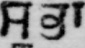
ਸੁਭਾ
